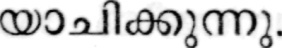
യാചിക്കുന്നു.
